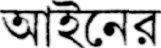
আইনের
